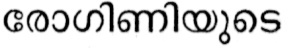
രോഗിണിയുടെ
